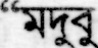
“মদুবু
